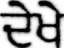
ਦੇਖੇ
